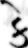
કે
